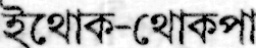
ইথোক-থোকপা
